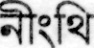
নীংথি
